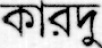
কারদু
